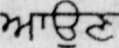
ਆਉਣ
